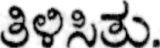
ತಿಳಿಸಿತು.
